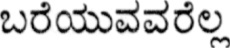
ಬರೆಯುವವರೆಲ್ಲ
